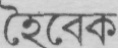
হৈবেক
